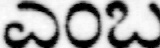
ಎಂಬ
